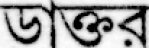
ডাক্তর
